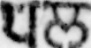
ਪਲ
